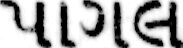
પાગલ
